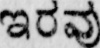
ಇರವು
